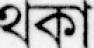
থকা
